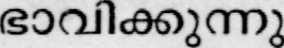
ഭാവിക്കുന്നു
